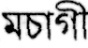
মচাগী
